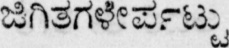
ಜಿಗಿತಗಳೇರ್ಪಟ್ಟು
